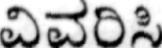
ವಿವರಿಸಿ
